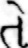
તે
